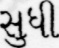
સુધી
